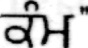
ਕੰਮ''
